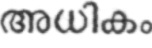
അധികം
